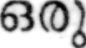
ഒരു
